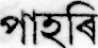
পাহৰি
